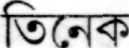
তিনেক
